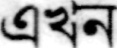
এখন
